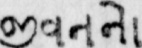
જીવનનો
